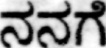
ನನಗೆ
